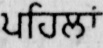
ਪਹਿਲਾਂ
